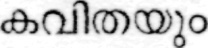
കവിതയും
